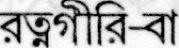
রত্নগীরি-বা
